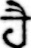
ਹੈ
